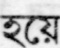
হয়ে
